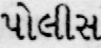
પોલીસ
